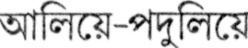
আলিয়ে-পদুলিয়ে
